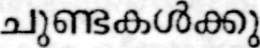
ചുണ്ടകള്‍ക്കു
